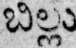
ಬಿಲ್ಲು
